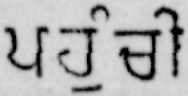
ਪਹੁੰਚੀ
